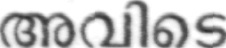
അവിടെ
